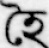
হৈ
